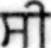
ਸੀ
